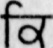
ਕਿ
